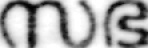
സഭ
